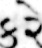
કરે
